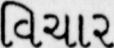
વિચાર
